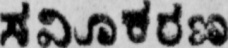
ಸಮೀಕರಣ
